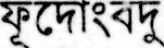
ফূদোংবদু
